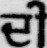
ਦੀ
